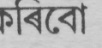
কৰিবো
